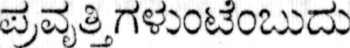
ಪ್ರವೃತ್ತಿಗಳುಂಟೆಂಬುದು
